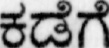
ಕಡೆಗೆ
